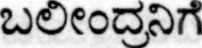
ಬಲೀಂದ್ರನಿಗೆ
